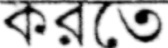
করতে
